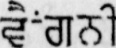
ਵੈਂਗਨੀ
